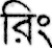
রিং
